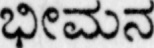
ಭೀಮನ
